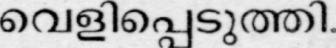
വെളിപ്പെടുത്തി.
